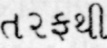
તરફથી
